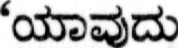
‘ಯಾವುದು
